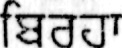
ਬਿਰਹਾ
